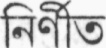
নির্ণীত
